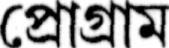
প্রোগ্রাম
